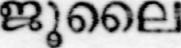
ജൂലൈ
